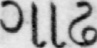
ગાઢ
